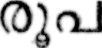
രൂപ
